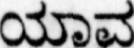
ಯಾವ
